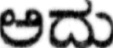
ಅದು
